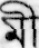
মী
